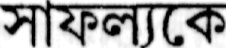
সাফল্যকে
